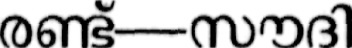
രണ്ട്-സൌദി
